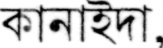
কানাইদা,
